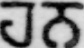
ਹਨ
